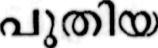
പുതിയ
